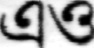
এও
